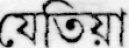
যেতিয়া
